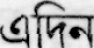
এদিন
